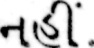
નહીં.
